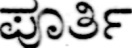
ಪೂರ್ತಿ
